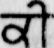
ਕੀ
